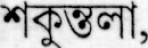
শকুন্তলা,
